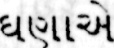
ઘણાએ
